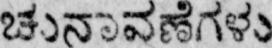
ಚುನಾವಣೆಗಳು
